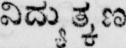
ವಿದ್ಯುತ್ಕಣ
